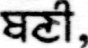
ਬਣੀ,
